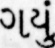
ગયું
